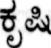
ಕೃಷಿ
